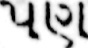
પણ
